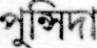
পুন্সিদা
